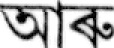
আৰু
